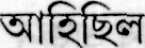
আহিছিল
